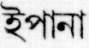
ইপানা
